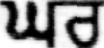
ਘਰ
